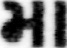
મા
